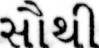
સૌથી
